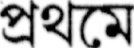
প্রথমে
